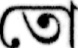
তো
